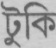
টুকি
